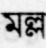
মল্ল
